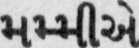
મમ્મીએ
